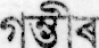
গম্ভীৰ
